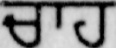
ਚਾਹ
